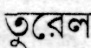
তুরেল
